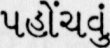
પહોંચવું
